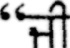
''ਜੀ
